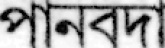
পানবদা
